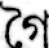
গৈ
